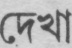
দেখা
